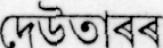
দেউতাৰৰ
